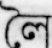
লৈ
